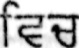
ਵਿਚ
